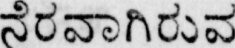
ನೆರವಾಗಿರುವ
